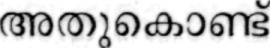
അതുകൊണ്ട്
